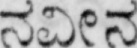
ನವೀನ
